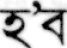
হ'ব
